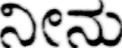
ನೀನು
